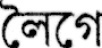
লৈগে
